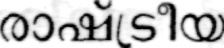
രാഷ്ട്രീയ
